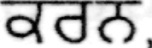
ਕਰਨ,
